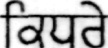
ਕਿਧਰੇ
